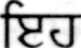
ਇਹ
